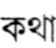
কথা
